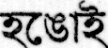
হঙোই
